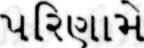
પરિણામે
